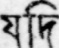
যদি
